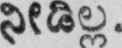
ನೀಡಿಲ್ಲ.
